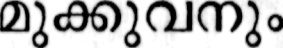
മുക്കുവനും
